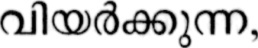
വിയര്‍ക്കുന്ന,
